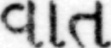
વાત
